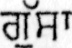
ਗੁੱਸਾ
